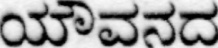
ಯೌವನದ
